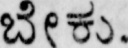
ಬೇಕು.
